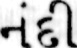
નંદી
